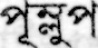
পুম্লুপ
